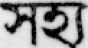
সহ্য
